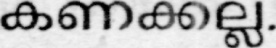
കണക്കല്ല.
